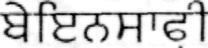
ਬੇਇਨਸਾਫ਼ੀ
